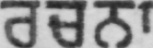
ਰਚਨਾ
